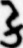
કે
